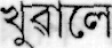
খুৱালে
